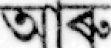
আৰু
